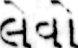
લેવો
